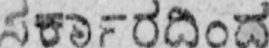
ಸರ್ಕಾರದಿಂದ
